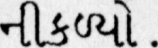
નીકળ્યો.
